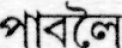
পাবলৈ
